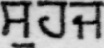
ਸੁਹਜ
